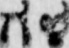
ಗಳ
